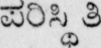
ಪರಿಸ್ಥಿತಿ
